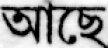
আছে
